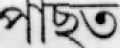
পাছত
